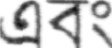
এবং
